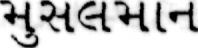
મુસલમાન
